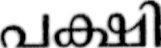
പക്ഷി
